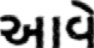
આવે
